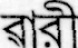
ৱারী
